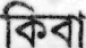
কিবা
